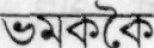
ভমককৈ
